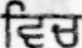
ਵਿਚ
